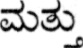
ಮತ್ತು
